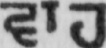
ਵਾਹ
